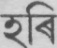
হৰি
